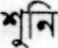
শুনি
